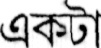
একটা
